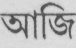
আজি
